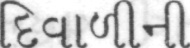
દિવાળીની
